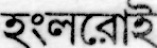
হংলরোই
